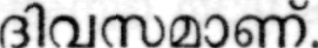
ദിവസമാണ്.
